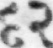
દર
